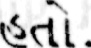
હતો.
